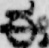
ಈ
